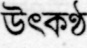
উত্কণ্ঠ
